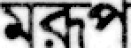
মরূপ
